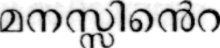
മനസ്സിന്റെ
